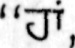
''ਹਾਂ,
